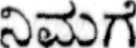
ನಿಮಗೆ
